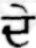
ਦੇ
